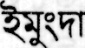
ইমুংদা
